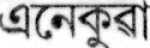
এনেকুৱা
